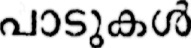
പാടുകള്‍
